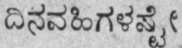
ದಿನವಹಿಗಳಷ್ಟೇ
